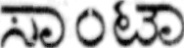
ಸಾಂಟಾ
